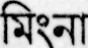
মিংনা
